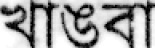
খাঙবা
